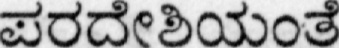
ಪರದೇಶಿಯಂತೆ
